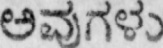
ಅವುಗಳು
